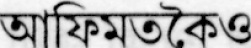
আফিমতকৈও
